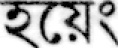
হয়েং
